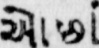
ઓછાં
